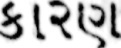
કારણ
